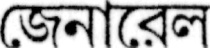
জেনারেল
